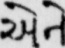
એને
